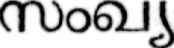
സംഖ്യ
